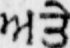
ਅਤੇ
